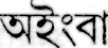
অইংবা
